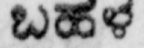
ಬಹಳ
